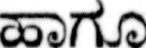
ಹಾಗೂ
